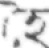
হৈ
